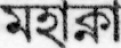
মহাক্না
